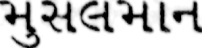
મુસલમાન
